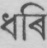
ধৰি
